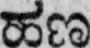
ಹಣ
